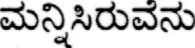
ಮನ್ನಿಸಿರುವೆನು
